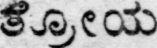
ತ್ರೋಯ
